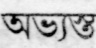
অভ্যস্ত
